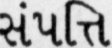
સંપત્તિ
